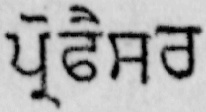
ਪ੍ਰੋਫੈਸਰ
